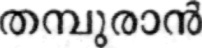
തമ്പുരാന്‍
